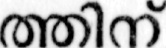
ത്തിന്
